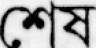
শেষ
